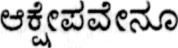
ಆಕ್ಷೇಪವೇನೂ
